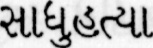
સાધુહત્યા
